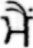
ਮੈਂ
